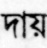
দায়
